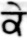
ਕੇ
